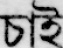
চাই
